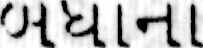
બધાના
